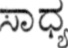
ಸಾಧ್ಯ
